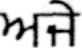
ਅਜੇ
